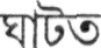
ঘাটত
